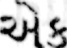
એક
